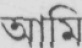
আমি
